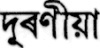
দূৰণীয়া
